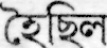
হৈছিল
